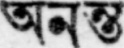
অনন্ত
